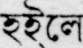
হইলে
